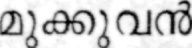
മുക്കുവന്‍
